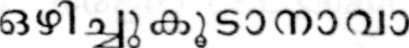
ഒഴിച്ചുകൂടാനാവാ
